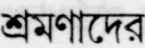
শ্রমণাদের
